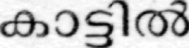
കാട്ടില്‍
